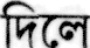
দিলে
